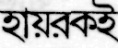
হায়রকই
